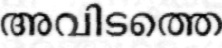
അവിടത്തെ
